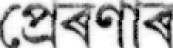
প্রেৰণাৰ
